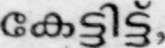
കേട്ടിട്ട്,
